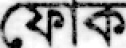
ফোক
